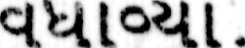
વધાવ્યા.
